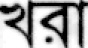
খরা
